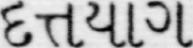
દત્તયાગ
